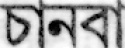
চানবা
